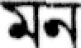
মন
